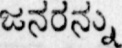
ಜನರನ್ನು
